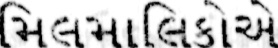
મિલમાલિકોએ
